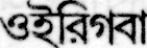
ওইরিগবা
